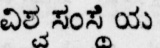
ವಿಶ್ವಸಂಸ್ಥೆಯ
